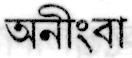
অনীংবা
